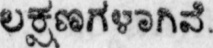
ಲಕ್ಷಣಗಳಾಗಿವೆ.
